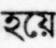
হয়ে
